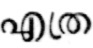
എത്ര
